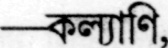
–কল্যাণি,
